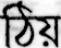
ঠিয়
